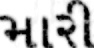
મારી
